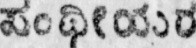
ಪ೦ಥೀಯರ
